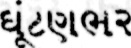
ઘૂંટણભર
